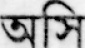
অসি
